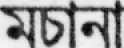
মচানা
